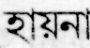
হায়না
